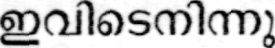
ഇവിടെനിന്നു
